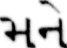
મને
